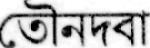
তৌনদবা
